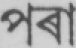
পৰা
